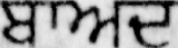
ਬਾਅਦ
